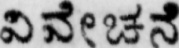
ವಿವೇಚನೆ
